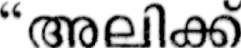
"അലിക്ക്
